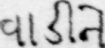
વાડીને
